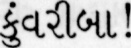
કુંવરીબા!
